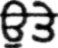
ਉਤੇ
